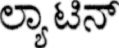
ಲ್ಯಾಟಿನ್
